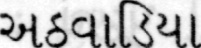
અઠવાડિયા
